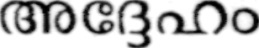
അദ്ദേഹം
